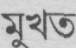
মুখত
